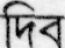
দিব
